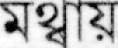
মথ্বায়
